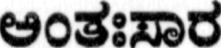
ಅಂತಃಸಾರ
